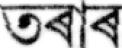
তৰাৰ
